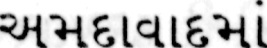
અમદાવાદમાં
